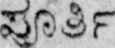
ಪೂರ್ತಿ
